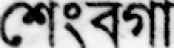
শেংবগা
